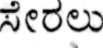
ಸೇರಲು
